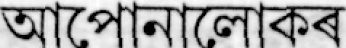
আপোনালোকৰ
